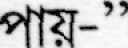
পায়-"
